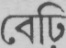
বেঢ়ি
